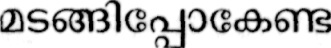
മടങ്ങിപ്പോകേണ്ട
